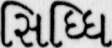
સિધ્ધિ
